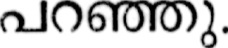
പറഞ്ഞു.
